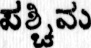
ಪಶ್ಚಿಮ
